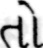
તો
